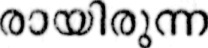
രായിരുന്ന
